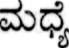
ಮಧ್ಯೆ
